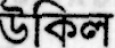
উকিল
